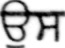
ਉਸ
